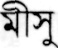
মীসু
